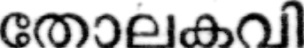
തോലകവി
